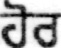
ਹੋਰ
